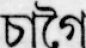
চাগৈ
